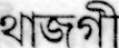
থাজগী
